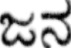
ಜನ
